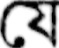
যে
